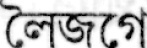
লৈজগে
